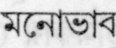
মনোভাব
